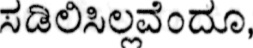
ಸಡಿಲಿಸಿಲ್ಲವೆಂದೂ,
